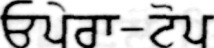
ਓਪੇਰਾ-ਟੋਪ
